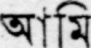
আমি
